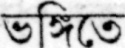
ভঙ্গিতে
